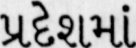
પ્રદેશમાં
